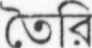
তৈরি
